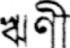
ঋণী
